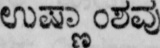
ಉಷ್ಣಾಂಶವು
